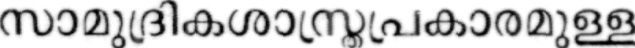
സാമുദ്രികശാസ്ത്രപ്രകാരമുള്ള
